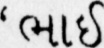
'ભાઈ
